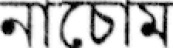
নাচোম
